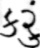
કરું
